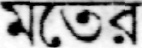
মতের
